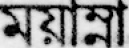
ময়াম্না
